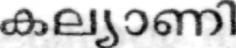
കല്യാണി
